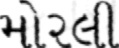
મોરલી
